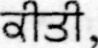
ਕੀਤੀ,
